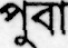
পুবা
